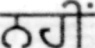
ਨਹੀਂ
